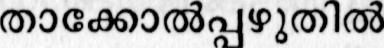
താക്കോല്‍പ്പഴുതില്‍
